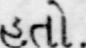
હતો.
